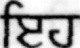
ਇਹ
